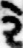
રે
